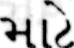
માટે
